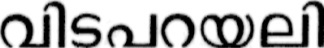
വിടപറയലി
